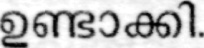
ഉണ്ടാക്കി.
